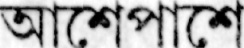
আশেপাশে
